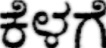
ಕೆಳಗೆ
